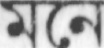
মনে
